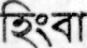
হিংবা
